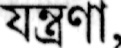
যন্ত্রণা,
